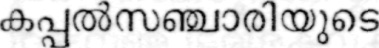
കപ്പല്‍സഞ്ചാരിയുടെ
